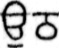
ਉਠ
